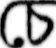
চে
